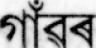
গাঁৱৰ
